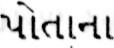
પોતાના
